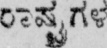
ರಾಷ್ಟ್ರಗಳ
